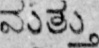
ಮತ್ತು
